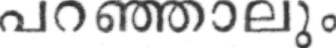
പറഞ്ഞാലും
